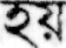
হয়
